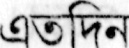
এতদিন
